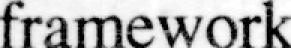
framework
